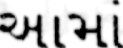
આમાં
